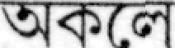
অকলে
